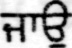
ਜਾਉ
